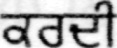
ਕਰਦੀ
